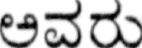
ಅವರು
